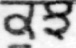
ਕੁਝ
